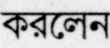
করলেন
